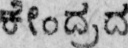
ಕೇಂದ್ರದ
